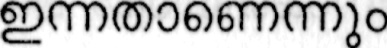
ഇന്നതാണെന്നും
